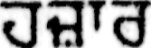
ਹਜ਼ਾਰ
